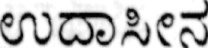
ಉದಾಸೀನ
